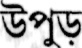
উপুড়
